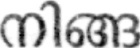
നിങ്ങ
